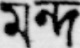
মন্দ
